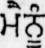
ਮੈਨੂੰ
